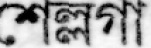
শেল্লগা
